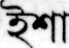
ইশা
